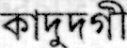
কাদুদগী
